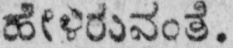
ಹೇಳಿರುವಂತೆ.
